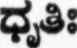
ಧೃತಿಃ
